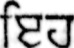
ਇਹ
